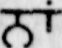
ਨਾਂ
